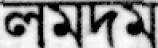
লমদম
